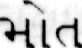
મોત
